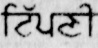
ਟਿੱਪਣੀ
